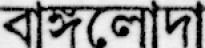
বাঙ্গলোদা
